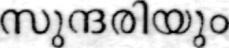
സുന്ദരിയും
